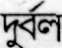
দুর্বল
